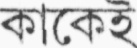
কাকেই
